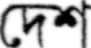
দেশ
